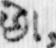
છો,
